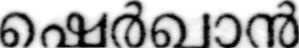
ഷെര്‍ഖാന്‍
